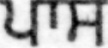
ਪਾਸ
